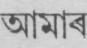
আমাৰ
